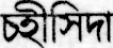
চহীসিদা
